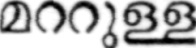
മററുള്ള
